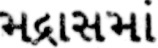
મદ્રાસમાં
